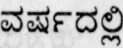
ವರ್ಷದಲ್ಲಿ
